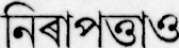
নিৰাপত্তাও
